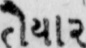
તૈયાર
